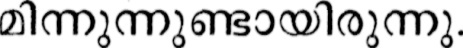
മിന്നുന്നുണ്ടായിരുന്നു.
